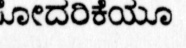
ಸೋದರಿಕೆಯೂ
